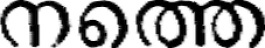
നത്തെ
